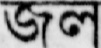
জল
